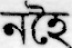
নহৈ
